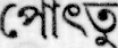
পোৎতু
